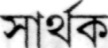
সার্থক
